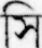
সি
